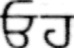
ਓਹ
